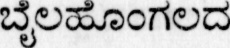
ಬೈಲಹೊಂಗಲದ
